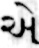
એ
